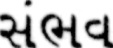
સંભવ
